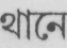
থানে
